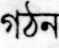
গঠন
